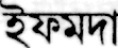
ইফমদা
